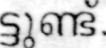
ട്ടുണ്ട്.
